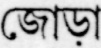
জোড়া
